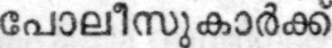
പോലീസുകാര്‍ക്ക്
